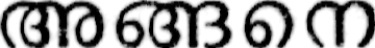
അങ്ങനെ
